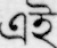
এই
